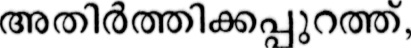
അതിര്‍ത്തിക്കപ്പുറത്ത്,
